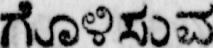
ಗೊಳಿಸುವ
